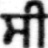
ਸੀ
